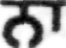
ਨਾ
